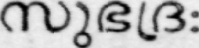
സുഭദ്ര:
